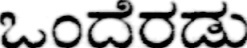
ಒಂದೆರಡು
